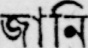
জানি
